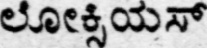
ಲೋಕ್ಸಿಯಸ್
